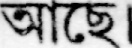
আছে।
